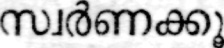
സ്വര്‍ണക്കൂ
